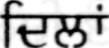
ਦਿਲਾਂ
